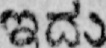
ಇದು
